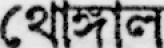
থোঙ্গাল
